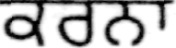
ਕਰਨਾ
